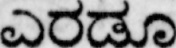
ಎರಡೂ
